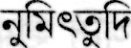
নুমিৎতুদি
